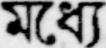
মধ্যে
